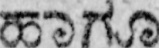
ಹಾಗೂ
